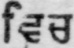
ਵਿਚ
